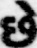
છે
